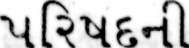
પરિષદની
